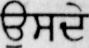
ਉਸਦੇ
